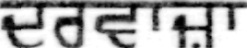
ਦਰਵਾਜ਼ਾ
